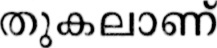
തുകലാണ്
